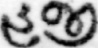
હજી
